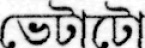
ভেটাটো
